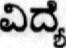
ವಿದ್ಯೆ
